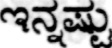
ಇನ್ನಷ್ಟು
